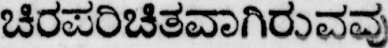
ಚಿರಪರಿಚಿತವಾಗಿರುವವು
